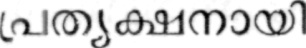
പ്രത്യക്ഷനായി
